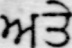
ਅਤੇ
